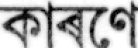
কাৰণে
